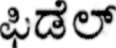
ಫಿಡೆಲ್
